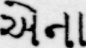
એના
